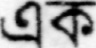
এক
